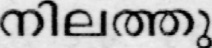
നിലത്തു
